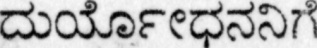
ದುರ್ಯೋಧನನಿಗೆ
